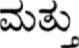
ಮತ್ತು
